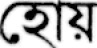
হোয়
